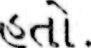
હતો.
